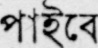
পাইবে
